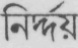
নিৰ্দ্দয়
